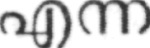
എന്ന
